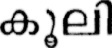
കൂലി
